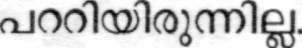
പററിയിരുന്നില്ല.
